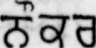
ਨੌਕਰ
